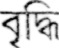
বৃদ্ধি
